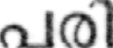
പരി
